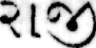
રાજી
